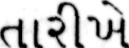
તારીખે
